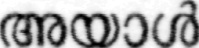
അയാള്‍
